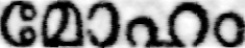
മോഹം
